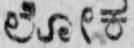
ಲೋಕ
